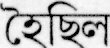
হৈছিল
